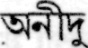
অনীদু
